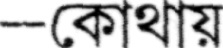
-কোথায়
